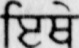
ਇਥੇ
